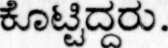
ಕೊಟ್ಟಿದ್ದರು.
